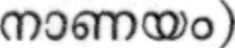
നാണയം)
